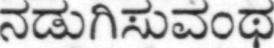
ನಡುಗಿಸುವಂಥ
